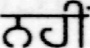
ਨਹੀਂ
